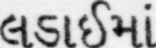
લડાઈમાં
